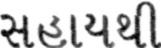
સહાયથી
